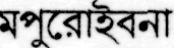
মপুরোইবনা
